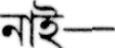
নাই-
